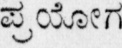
ಪ್ರಯೋಗ
